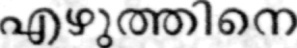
എഴുത്തിനെ
